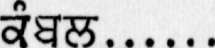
ਕੰਬਲ..............
